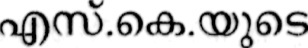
എസ്.കെ.യുടെ
